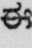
ಈ
